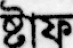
ষ্টাফ
